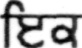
ਇਕ
